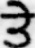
ਤੇ
